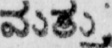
ಮತ್ತು
